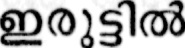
ഇരുട്ടില്‍
